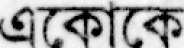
একোকে
